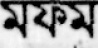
মফম
